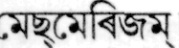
মেছ্‌মেৰিজম্
